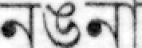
নঙনা
